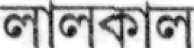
লালকাল
